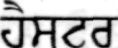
ਹੈਸਟਰ
